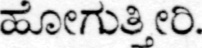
ಹೋಗುತ್ತೀರಿ.
